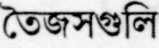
তৈজসগুলি
